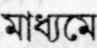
মাধ্যমে
